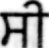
ਸੀ
